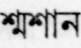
শ্মশান
